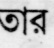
তার
